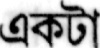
একটা
